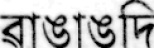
ৱাঙাঙদি
